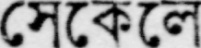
সেকেলে
